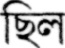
ছিল
